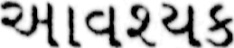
આવશ્યક
